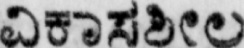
ವಿಕಾಸಶೀಲ
